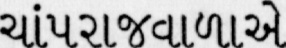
ચાંપરાજવાળાએ
